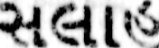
સલાહ
